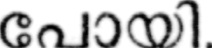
പോയി.
